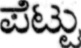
ಪೆಟ್ಟು
